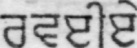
ਰਵਈਏ
